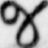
જ
